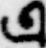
এ
